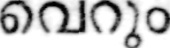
വെറും
